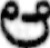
ಆ
